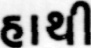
હાથી
